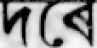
দৰে
